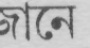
জানে
